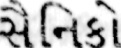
સૈનિકો
